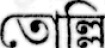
তোল্লি
